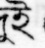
দুই
